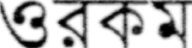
ওরকম
